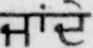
ਜਾਂਦੇ
